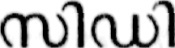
സിഡി
